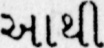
આથી
